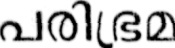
പരിഭ്രമ
